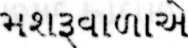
મશરૂવાળાએ
